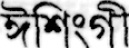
ঈশিংগী
